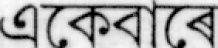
একেবাৰে
